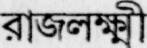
রাজলক্ষ্মী
